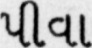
પીવા
